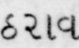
ઠરાવ
